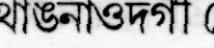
থাঙনাওদগী
